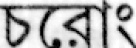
চরোং
